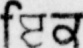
ਇਕ
